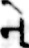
ને
